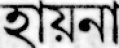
হায়না
